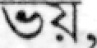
ভয়,
